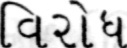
વિરોધ
